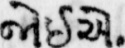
જોઈએ.
